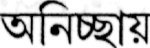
অনিচ্ছায়
